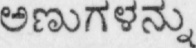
ಅಣುಗಳನ್ನು
